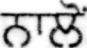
ਨਾਲੋਂ
